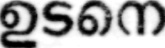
ഉടനെ
